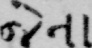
જેના
